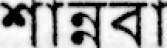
শান্নবা
